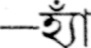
–হ্যাঁ
